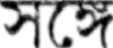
সঙ্গে
